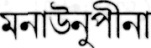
মনাউনুপীনা
